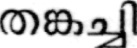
തങ്കച്ചി
